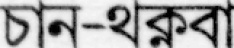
চান-থক্নবা
